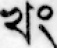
খং
